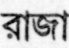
রাজা
